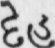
દેહ
